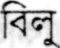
বিলু
